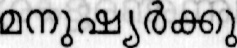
മനുഷ്യര്‍ക്കു
